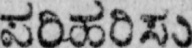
ಪರಿಹರಿಸು
